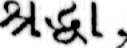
શ્રદ્ધા,
